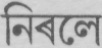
নিৰলে
